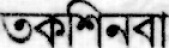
তকশিনবা
